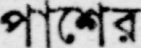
পাশের
